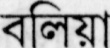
বলিয়া
